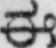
ಈ
